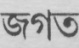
জগত
